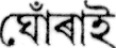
ঘোঁৰাই
